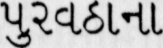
પુરવઠાના
